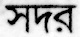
সদর
